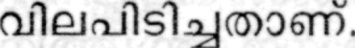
വിലപിടിച്ചതാണ്.
